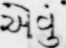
એવું
